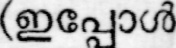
(ഇപ്പോള്‍
